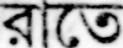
রাতে
